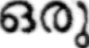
ഒരു
